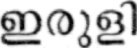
ഇരുളി
